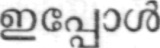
ഇപ്പോള്‍
